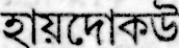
হায়দোকউ
